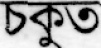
চকুত
